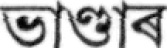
ভাণ্ডাৰ
